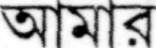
আমার
